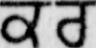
ਕਰ
